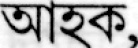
আহক,
